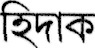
হিদাক
